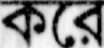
করে
